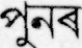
পুনৰ
